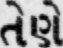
તેણે
